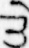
ਤੇ
